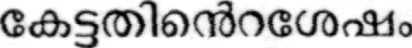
കേട്ടതിന്റെശേഷം
